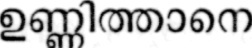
ഉണ്ണിത്താനെ
